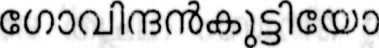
ഗോവിന്ദന്‍കുട്ടിയോ
